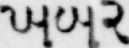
ખબર
